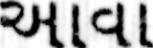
આવા
